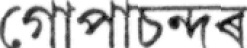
গোপাচন্দৰ
